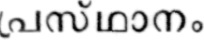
പ്രസ്ഥാനം
